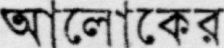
আলোকের
